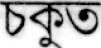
চকুত
